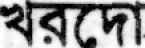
খরদো
